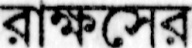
রাক্ষসের
